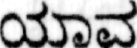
ಯಾವ
